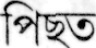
পিছত
